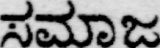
ಸಮಾಜ
